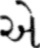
એ
